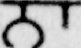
ਨਾ
